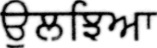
ਉਲਝਿਆ
